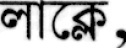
লাক্লে,
